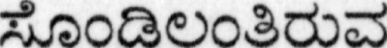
ಸೊಂಡಿಲಂತಿರುವ
